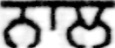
ਨਾਲ
